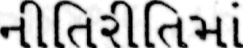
નીતિરીતિમાં
